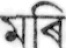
মৰি
